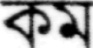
কম
